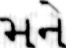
મને
